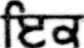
ਇਕ
